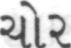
ચોર
